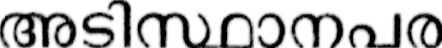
അടിസ്ഥാനപര
